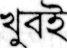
খুবই
